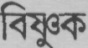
বিষ্ণুক
